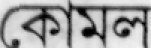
কোমল
